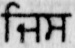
ਜਿਸ
